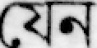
যেন
